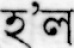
হ'ল
